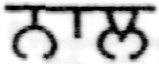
ਨਾਲ
